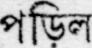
পড়িল
